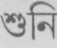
শুনি
